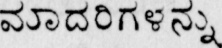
ಮಾದರಿಗಳನ್ನು
